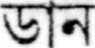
ডান
